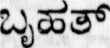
ಬೃಹತ್
